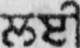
ਲਈ
